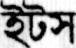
ইটস
